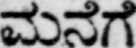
ಮನೆಗೆ
